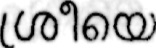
ശ്രീയെ
